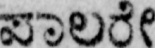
ಪಾಲರೇ
